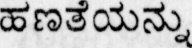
ಹಣತೆಯನ್ನು
